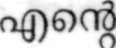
എന്റെ
